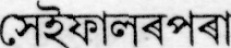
সেইফালৰপৰা
